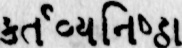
કર્તવ્યનિષ્ઠા
